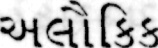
અલૌકિક
